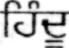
ਹਿੰਦੂ
